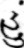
હું
